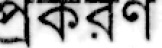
প্রকরণ
